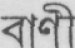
বাণী
